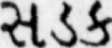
સડક
